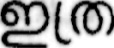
ഇത്ര
